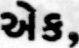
એક,
